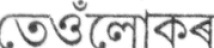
তেওঁলোকৰ
